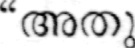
“അതു
